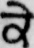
ਕੇ
